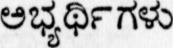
ಅಭ್ಯರ್ಥಿಗಳು
